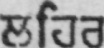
ਲਹਿਰ
